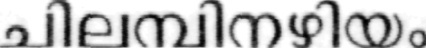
ചിലമ്പിനഴിയം
